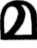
മ
